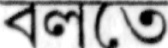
বলতে
